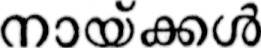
നായ്ക്കള്‍
